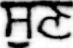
ਸੁਣ
